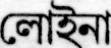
লোইনা
